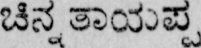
ಚಿನ್ನತಾಯಪ್ಪ
